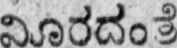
ಮಿರದಂತೆ
